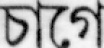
চাগে
